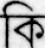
কি
